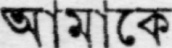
আমাকে
